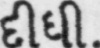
દીધી.
